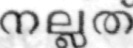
നല്ലത്
